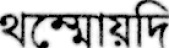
থম্মোয়দি
